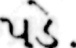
પડે.
